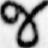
જ
